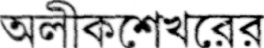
অলীকশেখরের
